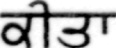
ਕੀਤਾ
